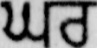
ਘਰ
